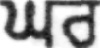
ਘਰ
